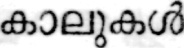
കാലുകള്‍
